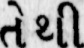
તેથી
